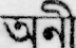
অনী
